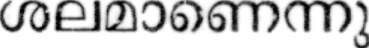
ശലമാണെന്നു
